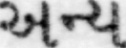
અન્ય
